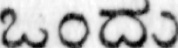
ಒಂದು
